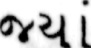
જ્યાં
